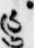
હું
